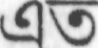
এত
